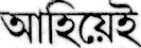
আহিয়েই
